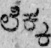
ಲೆಕ್ಕ
